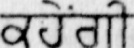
ਕਹੇਂਗੀ
